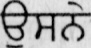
ਉਸਨੇ
